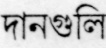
দানগুলি
